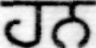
ਹਨ
